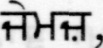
ਜੇਮਜ਼,
